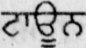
ਟਾਊਨ
